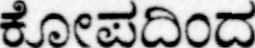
ಕೋಪದಿಂದ
